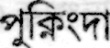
পুক্নিংদা
